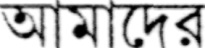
আমাদের
